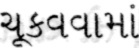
ચૂકવવામાં
